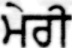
ਮੇਰੀ
